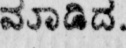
ಮಾಡಿದ.
